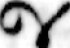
જ
